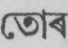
তোৰ
